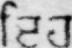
ਇਹ
